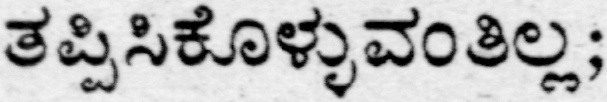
ತಪ್ಪಿಸಿಕೂಳ್ಳುವಂತಿಲ್ಲ್ಲ
